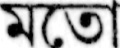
মতো
